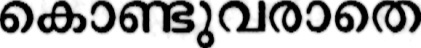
കൊണ്ടുവരാതെ
